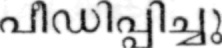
പീഡിപ്പിച്ചു
